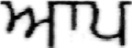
ਆਪ
